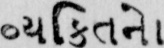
વ્યક્તિનો
